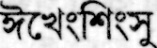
ঈখেংশিংসু
